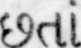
છતાં
